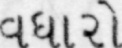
વધારો
